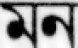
মন
